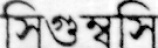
সিগুম্বসি
